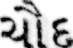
ચૌદ
